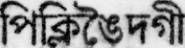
পিক্লিঙৈদগী
